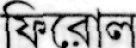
ফিরোল
